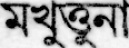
মখুত্তুনা
